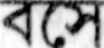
বসে
